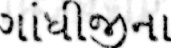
ગાંધીજીના
